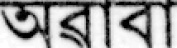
অৱাবা
